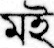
মই
